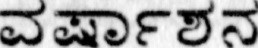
ವರ್ಷಾಶನ
